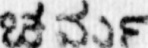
ಚರ್ಮ
